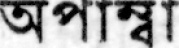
অপাম্বা
